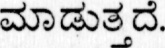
ಮಾಡುತ್ತದೆ.
